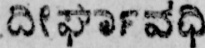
ದೀರ್ಘಾವಧಿ
